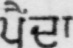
ਪੈਦਾ
